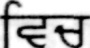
ਵਿਚ
